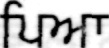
ਪਿਆ
